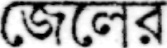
জেলের
